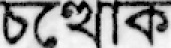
চত্থোক
